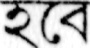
হবে
